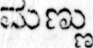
ಮಣ್ಣು
